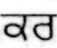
ਕਰ
